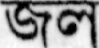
জল
